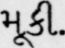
મૂકી.
